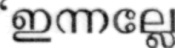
'ഇന്നല്ലേ
